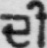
ਦੀ
